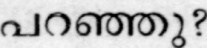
പറഞ്ഞു?
